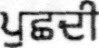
ਪੁਛਦੀ
